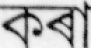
কৰা
